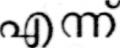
എന്ന്
